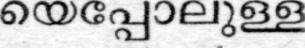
യെപ്പോലുള്ള
